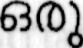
ഒരു
